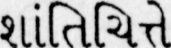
શાંતિચિત્તે
